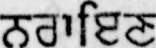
ਨਰਾਇਣ
